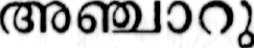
അഞ്ചാറു
